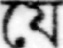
যে
